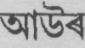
আউৰ
